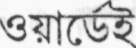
ওয়ার্ডেই
